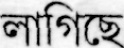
লাগিছে
